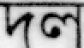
দল
